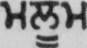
ਮਲੂਮ
